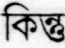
কিন্তু
